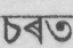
চৰত
